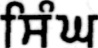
ਸਿੰਘ
